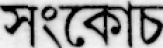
সংকোচ
